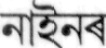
নাইনৰ
